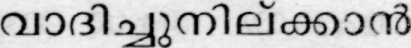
വാദിച്ചുനില്ക്കാന്‍
